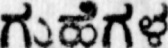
ಗುಹೆಗಳ
